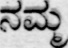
ನಮ್ಮ
